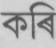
কৰি
